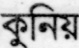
কুনিয়
